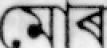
মোৰ
